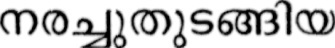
നരച്ചുതുടങ്ങിയ
